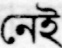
নেই
